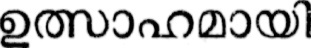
ഉത്സാഹമായി
